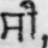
ਸੀ,
